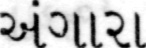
અંગારા
